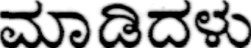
ಮಾಡಿದಳು
